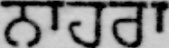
ਨਾਹਰਾ
